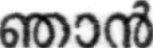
ഞാന്‍
